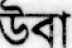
উবা
